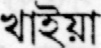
খাইয়া
